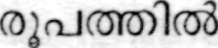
രൂപത്തില്‍
